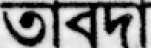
তাবদা
